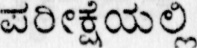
ಪರೀಕ್ಷೆಯಲ್ಲಿ
